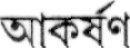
আকর্ষণ
